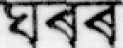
ঘৰৰ
